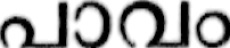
പാവം
